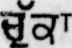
ਚੁੱਕਾ
